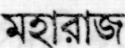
মহারাজ
